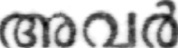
അവര്‍
